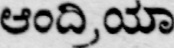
ಆ೦ದ್ರಿಯಾ
